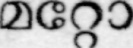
മറ്റോ
